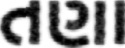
તણા
